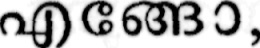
എങ്ങോ,
